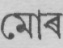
মোৰ
